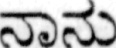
ನಾನು
